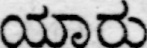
ಯಾರು
